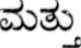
ಮತ್ತು
